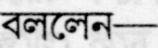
বললেন–
